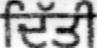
ਦਿੱਤੀ
